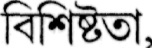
বিশিষ্টতা,
